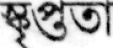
স্কৃপতা
